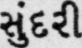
સુંદરી
